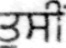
ਤੁਸੀਂ
